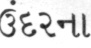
ઉંદરના
